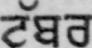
ਟੱਬਰ
